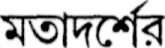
মতাদর্শের
